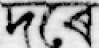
দৰে
